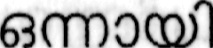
ഒന്നായി
